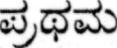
ಪ್ರಥಮ
